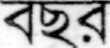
বছর
